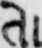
તો
